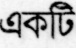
একটি
